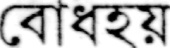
বোধহয়
